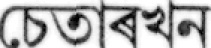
চেতাৰখন
